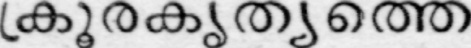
ക്രൂരകൃത്യത്തെ
